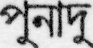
পুনাদু
